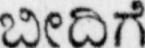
ಬೀದಿಗೆ
